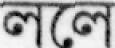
ললে
